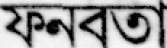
ফনবদা
